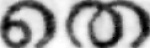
തെ
